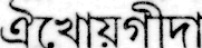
ঐখোয়গীদা
